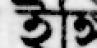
মপা
